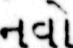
નવો
